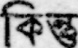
কিন্তু
